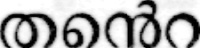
തന്റെ
